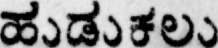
ಹುಡುಕಲು
